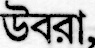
উবরা,
